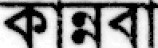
কান্নবা
